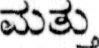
ಮತ್ತು
